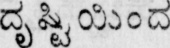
ದೃಷ್ಟಿಯಿಂದ
